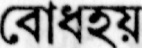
বোধহয়
